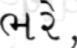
ભરે,
